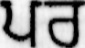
ਪਰ
